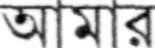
আমার
